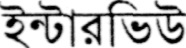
ইন্টারভিউ
